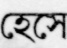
হেসে
